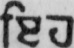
ਇਹ
